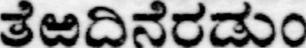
ತೆಱದಿನೆರಡುಂ
